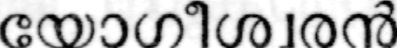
യോഗീശ്വരന്‍
